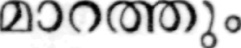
മാറത്തും
